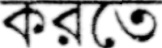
করতে
